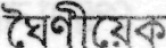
ঘৈণীয়েক
